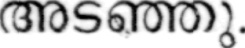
അടഞ്ഞു.
